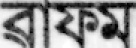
ৱাফম
